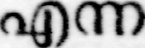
എന്ന
